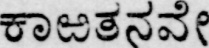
ಕಾಱತನವೇ
